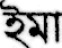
ইমা
